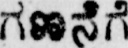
ಗಣನೆಗೆ
